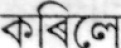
কৰিলে
